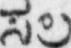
ಸಲ
